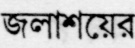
জলাশয়ের
